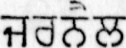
ਜਰਨੈਲ
